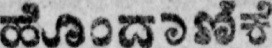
ಹೊಂದಾಣಿಕೆ
